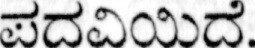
ಪದವಿಯಿದೆ.
